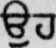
ਉਹ
